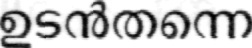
ഉടന്‍തന്നെ
